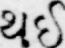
થઈ
